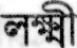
লক্ষ্মী
